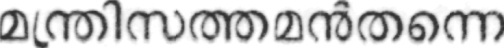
മന്ത്രിസത്തമന്‍തന്നെ
